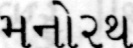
મનોરથ
